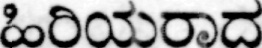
ಹಿರಿಯರಾದ
